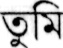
তুমি
